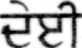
ਦੇਈ
